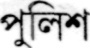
পুলিশ
